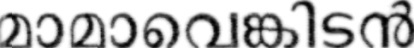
മാമാവെങ്കിടന്‍
